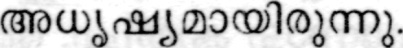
അധൃഷ്യമായിരുന്നു.
